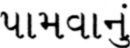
પામવાનું
